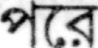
পরে
